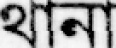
থানা
